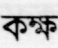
কক্ষ
